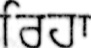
ਰਿਹਾ
